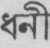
ধনী
